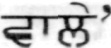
ਵਾਲੇ'
